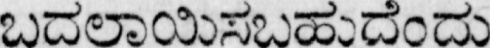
ಬದಲಾಯಿಸಬಹುದೆಂದು
